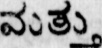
ಮತ್ತು
